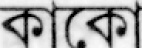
কাকো
